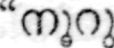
“നൂറു
